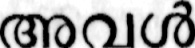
അവള്‍
